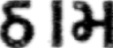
ઠામ
